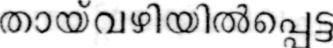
തായ്വഴിയില്‍പ്പെട്ട
